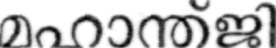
മഹാന്ത്ജി
